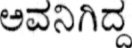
ಅವನಿಗಿದ್ದ
